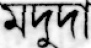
মদুদা
